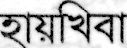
হায়খিবা
